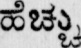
ಹೆಚ್ಚು
